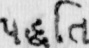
પદ્ધતિ
